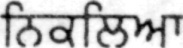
ਨਿਕਲਿਆ
